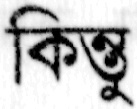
কিন্তু
